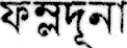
ফম্লদূনা
